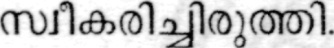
സ്വീകരിച്ചിരുത്തി.
